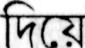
দিয়ে
